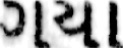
ગયા
